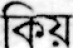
কিয়
